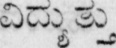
ವಿದ್ಯುತ್ತು
